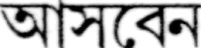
আসবেন
